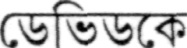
ডেভিডকে
